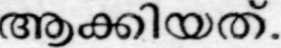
ആക്കിയത്.
